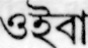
ওইবা
